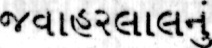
જવાહરલાલનું
